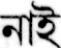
নাই
